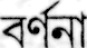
বৰ্ণনা
